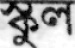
স্কুল
